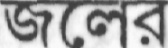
জলের
